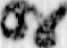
જ
